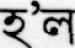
হ'ল
